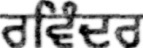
ਰਵਿੰਦਰ
